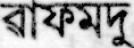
ৱাফমদু
